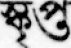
স্কৃপ্ত
